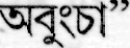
অবুংচা”
